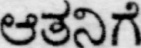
ಆತನಿಗೆ
